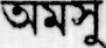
অমসু
